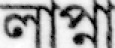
লাপ্না
